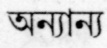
অন্যান্য
